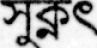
সুক্নৎ
